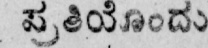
ಪ್ರತಿಯೊಂದು
